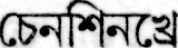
চেনশিনখ্রে
